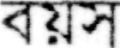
বয়স
